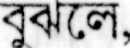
বুঝলে,
